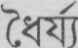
ধৈৰ্য্য
